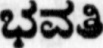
ಭವತಿ
